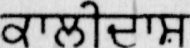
ਕਾਲੀਦਾਸ
